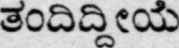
ತಂದಿದ್ದೀಯೆ
